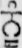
ਨੂੰ
